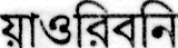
য়াওরিবনি
